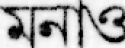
মনাও
